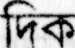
দিক
